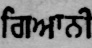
ਗਿਆਨੀ
